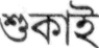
শুকাই
